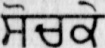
ਸੋਚਕੇ
